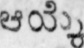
ಆಯ್ಕೆ
